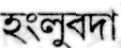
হংলুবদা
